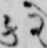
કરે
